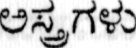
ಅಸ್ತ್ರಗಳು
